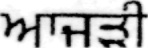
ਆਜੜੀ
